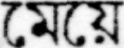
মেয়ে
